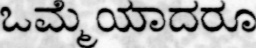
ಒಮ್ಮೆಯಾದರೂ
